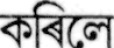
কৰিলে
